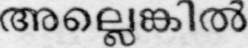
അല്ലെങ്കില്‍
